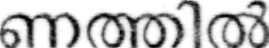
ണത്തില്‍
